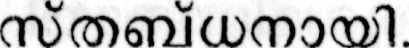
സ്തബ്ധനായി.
